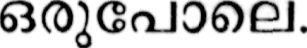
ഒരുപോലെ.
